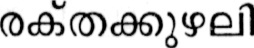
രക്തക്കുഴലി
